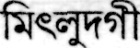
মিৎলুদগী
